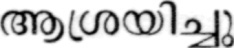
ആശ്രയിച്ചു
